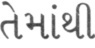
તેમાંથી
